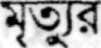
মৃত্যুর
